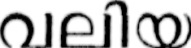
വലിയ
